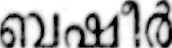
ബഷീര്‍
